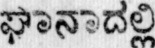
ಘಾನಾದಲ್ಲಿ
